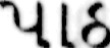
પાઠ
